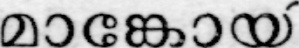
മാങ്കോയി
